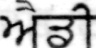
ਐਡੀ
